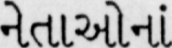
નેતાઓનાં
